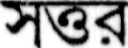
সত্তর
